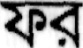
ফর
